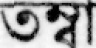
তম্বা
